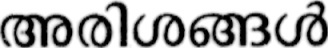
അരിശങ്ങള്‍
